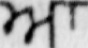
ਆ
